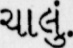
ચાલું.
